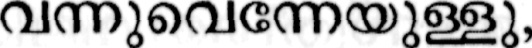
വന്നുവെന്നേയുള്ളു,
